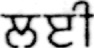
ਲਈ
